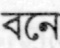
বনে
